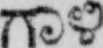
ಗಾಳಿ
